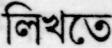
লিখতে
